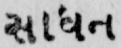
સાધન
